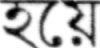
হয়ে
